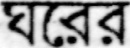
ঘরের
